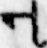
ન
